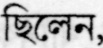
ছিলেন,
